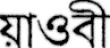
য়াওবী
